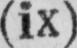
(ix)
